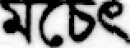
মচেৎ
